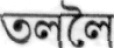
তললৈ
